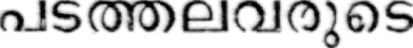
പടത്തലവരുടെ
